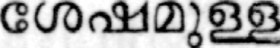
ശേഷമുള്ള
